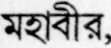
মহাবীর,
